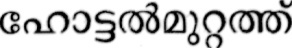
ഹോട്ടല്‍മുറ്റത്ത്
